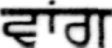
ਵਾਂਗ
